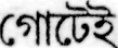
গোটেই
